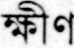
ক্ষীণ
